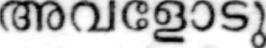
അവളോടു
